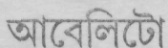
আবেলিটো
